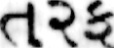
તરફ
